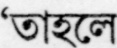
‘তাহলে
